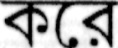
করে
